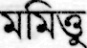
মমিত্তু
